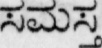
ಸಮಸ್ತ
